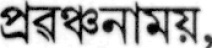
প্রৱঞ্চনাময়,
